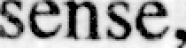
sense,
